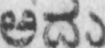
ಅದು
